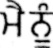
ਮੈਨੂੰ
